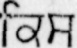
ਕਿਸ
